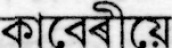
কাবেৰীয়ে
